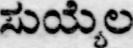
ಸುಯ್ಯೆಲ
